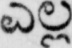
ಎಲ್ಲ
